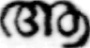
ആ
